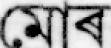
মোৰ
